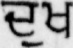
ਦੁਖ
